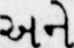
અને
